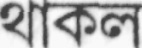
থাকল
